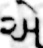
એ
